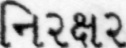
નિરક્ષર
